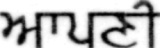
ਆਪਣੀ
